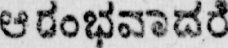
ಆರಂಭವಾದರೆ
